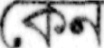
কেন
